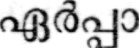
ഏര്‍പ്പാ
